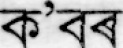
ক'বৰ
